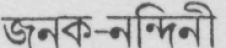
জনক-নন্দিনী
